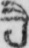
ਹੈ
